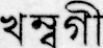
খম্বগী
